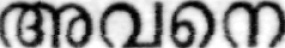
അവനെ
